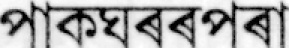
পাকঘৰৰপৰা
